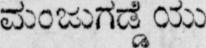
ಮಂಜುಗಡ್ಡೆಯು
